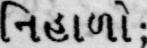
નિહાળો;
